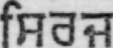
ਸਿਰਜ
